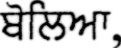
ਬੋਲਿਆ,
